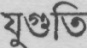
যুগুতি
